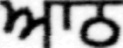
ਆਠ
